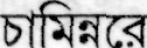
চামিন্নরে
